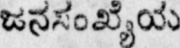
ಜನಸಂಖ್ಯೆಯ
